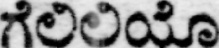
ಗೆಲಿಲಿಯೊ
